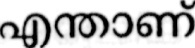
എന്താണ്
